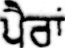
ਪੈਰਾਂ
